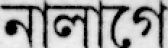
নালাগে
